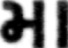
મા
